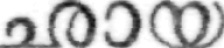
ഛായ
